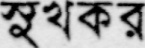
সুখকর
